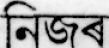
নিজৰ
